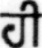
ਹੀ
